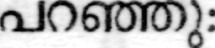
പറഞ്ഞു:
